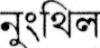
নুংথিল
